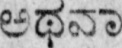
ಅಥವಾ
